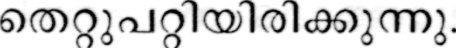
തെറ്റുപറ്റിയിരിക്കുന്നു.
